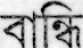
বান্ধি
